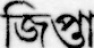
জিপ্তা
